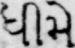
ધીમે
